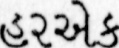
હરએક
